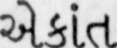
એકાંત
